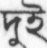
দুই
